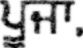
ਪੂਜਾ,
